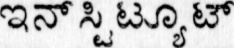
ಇನ್‌ಸ್ಟಿಟ್ಯೂಟ್
